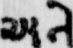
અને
